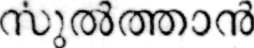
സുല്‍ത്താന്‍
